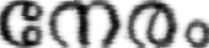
നേരം
